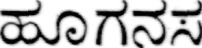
ಹೂಗನಸ
